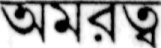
অমরত্ব
